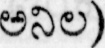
ಅನಿಲ)
